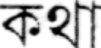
কথা
